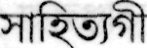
সাহিত্যগী
